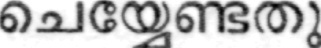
ചെയ്യേണ്ടതു
